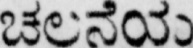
ಚಲನೆಯ
